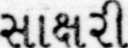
સાક્ષરી
